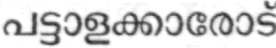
പട്ടാളക്കാരോട്
